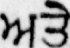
ਅਤੇ
